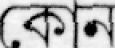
কোন
